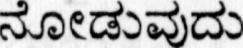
ನೋಡುವುದು
